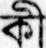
কী
